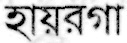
হায়রগা
